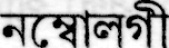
নম্বোলগী
